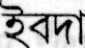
ইবদা
